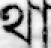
থা
